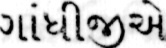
ગાંધીજીએ
